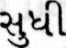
સુધી
